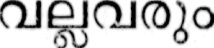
വല്ലവരും
